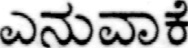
ಎನುವಾಕೆ
